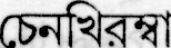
চেনখিরম্বা
